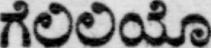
ಗೆಲಿಲಿಯೊ
